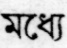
মধ্যে
